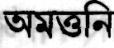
অমত্তনি
